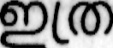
ഇത്ര
